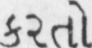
કરતો
